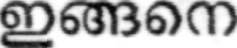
ഇങ്ങനെ
